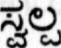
ಸ್ವಲ್ಪ
